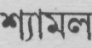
শ্যামল
